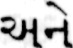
અને
